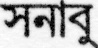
সনাবু
